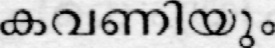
കവണിയും
